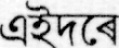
এইদৰে
